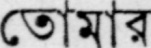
তোমার
